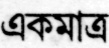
একমাত্র
